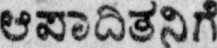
ಆಪಾದಿತನಿಗೆ
